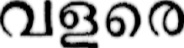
വളരെ
